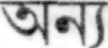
অন্য
